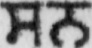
ਸਨ
